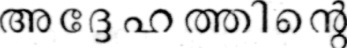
അദ്ദേഹത്തിന്റെ
